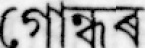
গোন্ধৰ
